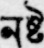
নষ্ট
